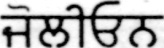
ਜੋਲੀਓਨ
